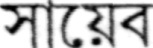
সায়েব
